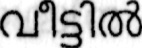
വീട്ടില്‍
